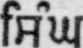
ਸਿੰਘ
